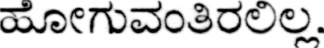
ಹೋಗುವಂತಿರಲಿಲ್ಲ.
